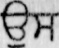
ਉਸ
